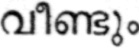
വീണ്ടും
